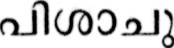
പിശാചു
